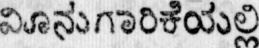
ಮೀನುಗಾರಿಕೆಯಲ್ಲಿ
